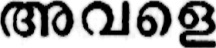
അവളെ
